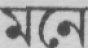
মনে
